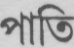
পাতি
